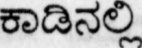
ಕಾಡಿನಲ್ಲಿ
